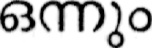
ഒന്നും
